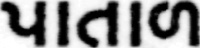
પાતાળ
